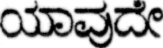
ಯಾವುದೇ
